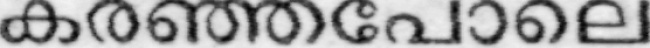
കരഞ്ഞപോലെ
